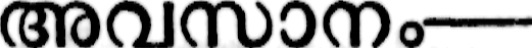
അവസാനം-
